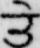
ਤੇ
